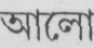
আলো
